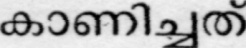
കാണിച്ചത്
